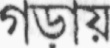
গড়ায়
